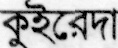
কুইরেদা
